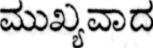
ಮುಖ್ಯವಾದ
